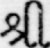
શ્રી
